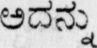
ಅದನ್ನು
